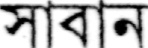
সাবান
